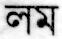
লম
